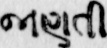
જાણતી
